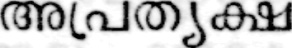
അപ്രത്യക്ഷ
